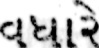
વધારે
